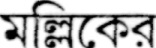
মল্লিকের
